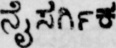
ನೈಸರ್ಗಿಕ
